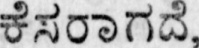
ಕೆಸರಾಗದೆ,
